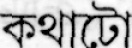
কথাটো
